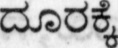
ದೂರಕ್ಕೆ
